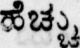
ಹೆಚ್ಚು
